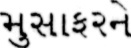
મુસાફરને
